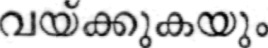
വയ്ക്കുകയും
